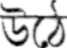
উঠে
